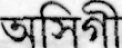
অসিগী
